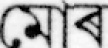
মোৰ
